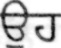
ਉਹ
